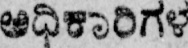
ಅಧಿಕಾರಿಗಳ
